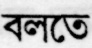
বলতে
